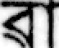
ৱা
